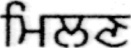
ਮਿਲਣ
